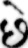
છે
